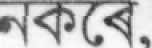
নকৰে,
